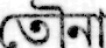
তৌনা
